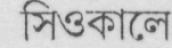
সিওকালে
